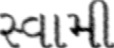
સ્વામી
